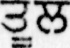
ਤੂਲ
